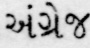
અંગ્રેજ
